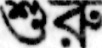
শুরু
